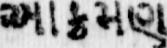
આક્રમણ
